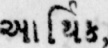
આર્થિક,
